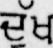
ਦੁੱਖ
